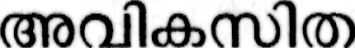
അവികസിത
